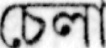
চেলা
